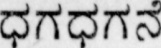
ಧಗಧಗನೆ
